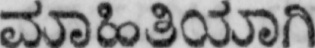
ಮಾಹಿತಿಯಾಗಿ
